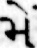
મેં
